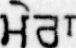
ਮੇਰਾ
